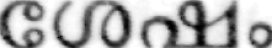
ശേഷം
